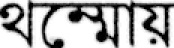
থম্মোয়
